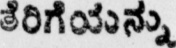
ತೆರಿಗೆಯನ್ನು
